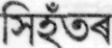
সিহঁতৰ
